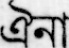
ঐনা
